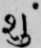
શું
